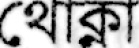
থোক্না
